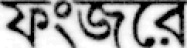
ফংজরে
